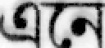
এনে
